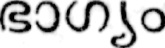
ഭാഗ്യം
